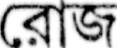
রোজ
